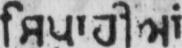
ਸਿਪਾਹੀਆਂ
